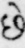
છે
